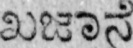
ಖಜಾನೆ
